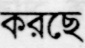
করছে
